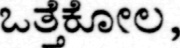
ಒತ್ತೆಕೋಲ,
